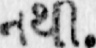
નથી.
